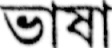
ভাষা
